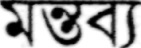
মন্তব্য
